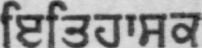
ਇਤਿਹਾਸਕ
